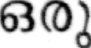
ഒരു
